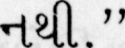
નથી."
